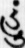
હું
